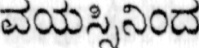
ವಯಸ್ಸಿನಿಂದ
